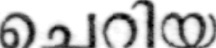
ചെറിയ
